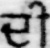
ਦੀ
